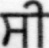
ਸੀ
